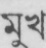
মুখ
